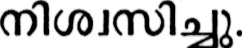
നിശ്വസിച്ചു.
